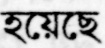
হয়েছে
